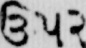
ઉપર
